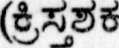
(ಕ್ರಿಸ್ತಶಕ
